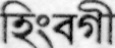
হিংবগী
